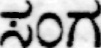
ಸಂಗ
